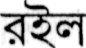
রইল
